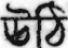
উঠি
